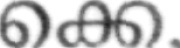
ക്കെ.
